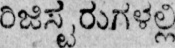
ರಿಜಿಸ್ಟರುಗಳಲ್ಲಿ
